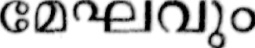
മേഘവും
